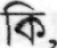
কি,
